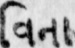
વિના
